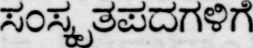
ಸಂಸ್ಕೃತಪದಗಳಿಗೆ
